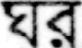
ঘর
